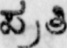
ಪ್ರತಿ
